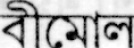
বীমোল
